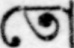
তো
